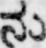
ನು
